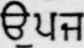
ਉਪਜ
